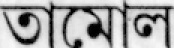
তামোল
